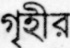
গৃহীর
